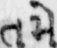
તમે
